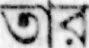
তার
